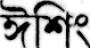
ঈশিং
